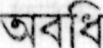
অবধি
